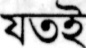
যতই
